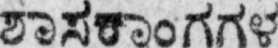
ಶಾಸಕಾಂಗಗಳ
